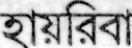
হায়রিবা
